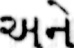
અને
